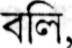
বলি,
